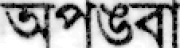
অপঙবা
